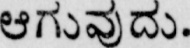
ಆಗುವುದು.
